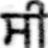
ਸੀ
